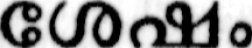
ശേഷം
